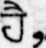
ਹੈ,
